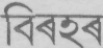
বিৰহৰ
